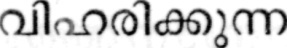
വിഹരിക്കുന്ന
